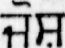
ਜੋਸ਼
